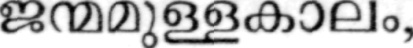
ജന്മമുള്ളകാലം,
